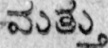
ಮತ್ತು
